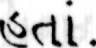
હતાં.
